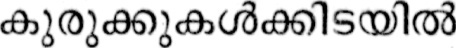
കുരുക്കുകള്‍ക്കിടയില്‍
